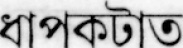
ধাপকটাত
